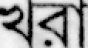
খরা
